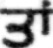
ਤਾਂ
